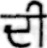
ਦੀ
